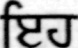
ਇਹ
